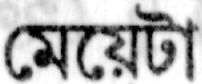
মেয়েটা
